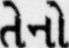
તેનો
